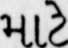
માટે
